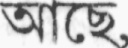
আছে,
